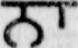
ਨਾ
